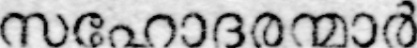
സഹോദരന്മാര്‍
